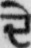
ਦੇ
